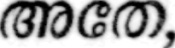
അതേ,
